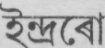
ইন্দ্ৰৰো
